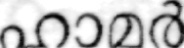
ഹാമര്‍
